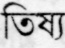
তিষ্য
